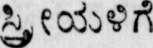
ಸ್ತ್ರೀಯಳಿಗೆ
